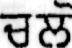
ਚਲੋ
